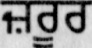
ਜ਼ਰੂਰ
